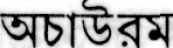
অচাউরম
